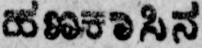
ಹಣಕಾಸಿನ
